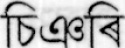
চিঞৰি
